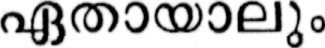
ഏതായാലും
